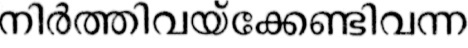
നിര്‍ത്തിവയ്ക്കേണ്ടിവന്ന
